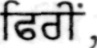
ਫਿਰੀਂ,
